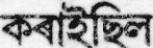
কৰাইছিল
